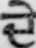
ਦੇ
